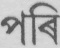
পৰি
